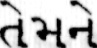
તેમને
